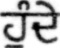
ਹੁੰਦੇ
